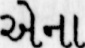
એના
